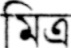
মিত্র
